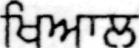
ਖਿਆਲ
